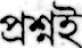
প্রশ্নই
